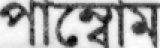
পাম্বোম
